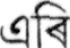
এৰি
